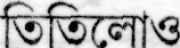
তিতিলোও
